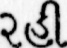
રહી
